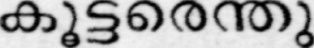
കൂട്ടരെന്തു
